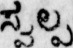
ಸ್ವಲ್ಪ
